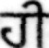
ਹੀ
